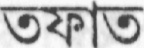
তফাত
